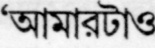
‘আমারটাও
